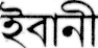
ইবানী
